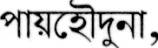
পায়হৌদুনা,
